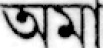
অমা
